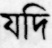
যদি
